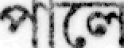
পালে
